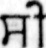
ਸੀ
